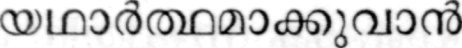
യഥാര്‍ത്ഥമാക്കുവാന്‍
